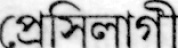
প্রেসিলাগী
